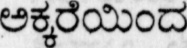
ಅಕ್ಕರೆಯಿಂದ
